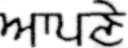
ਆਪਣੇ
